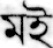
মই
